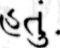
હતું.
